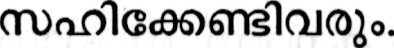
സഹിക്കേണ്ടിവരും.
